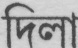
দিলা
